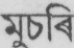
মুচৰি
